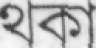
থকা
